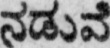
ನಡುವೆ
